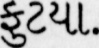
ફુટયા.
